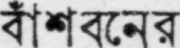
বাঁশবনের
